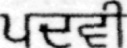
ਪਦਵੀ
